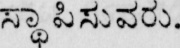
ಸ್ಥಾಪಿಸುವರು.
